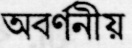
অবর্ণনীয়
